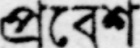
প্রবেশ
